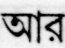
আর
